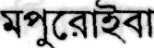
মপুরোইবা
